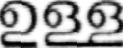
ഉള്ള
